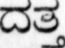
ದತ್ತ
